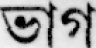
ভাগ
